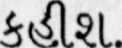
કહીશ.
